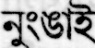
নুংঙাই
